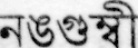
নঙগুম্বী
